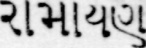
રામાયણ
